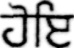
ਹੋਇ
